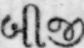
બીજી
